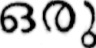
ഒരു
